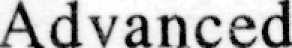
Advanced
